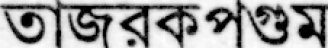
তাজরকপগুম
